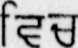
ਵਿਚ
